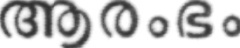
ആരംഭം
